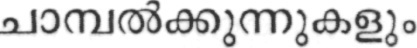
ചാമ്പല്‍ക്കുന്നുകളും
